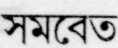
সমবেত
